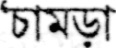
‘চামড়া
